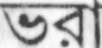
ভরা
